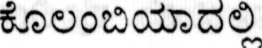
ಕೊಲಂಬಿಯಾದಲ್ಲಿ
